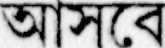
আসবে
